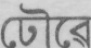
ঢৌৱে
